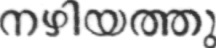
നഴിയത്തു
